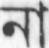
না
